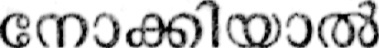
നോക്കിയാല്‍
